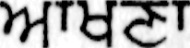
ਆਖਣਾ
